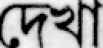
দেখা
